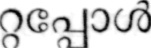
റ്റപ്പോള്‍
